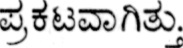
ಪ್ರಕಟವಾಗಿತ್ತು.
